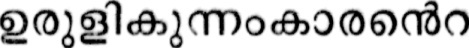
ഉരുളികുന്നംകാരന്റെ
